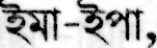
ইমা-ইপা,
